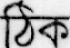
ঠিক
